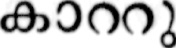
കാററു
